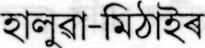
হালুৱা-মিঠাইৰ
